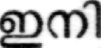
ഇനി
